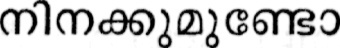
നിനക്കുമുണ്ടോ
